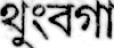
থুংবগা
